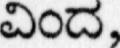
ವಿಂದ,
